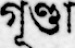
গূণ্ডা
